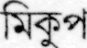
মিকুপ
